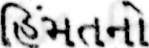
હિંમતનો
